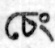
চেং
